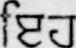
ਇਹ
